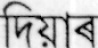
দিয়াৰ
